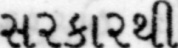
સરકારથી
